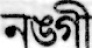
নঙগী
